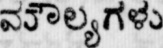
ಮೌಲ್ಯಗಳು
